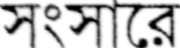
সংসারে
